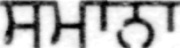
ਸਮਾਨਾ
